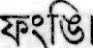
ফংঙি।
